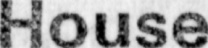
House
